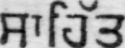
ਸਾਹਿੱਤ
